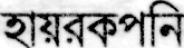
হায়রকপনি
